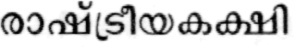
രാഷ്ട്രീയകക്ഷി
